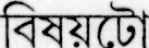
বিষয়টো
